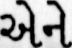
એને
